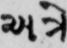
અત્રે
